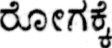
ರೋಗಕ್ಕೆ
